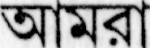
আমরা
